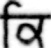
ਕਿ
